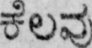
ಕೆಲವು
